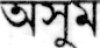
অসুম
